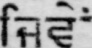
ਜਿਵੇਂ
